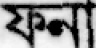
ফনা
